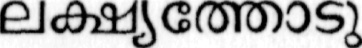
ലക്ഷ്യത്തോടു
